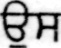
ਉਸ
